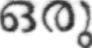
ഒരു
